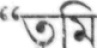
"তুমি
